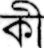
কী
